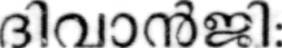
ദിവാന്‍ജി:
